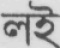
লই
